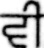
ਵੀ
